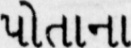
પોતાના
